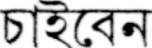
চাইবেন
